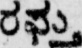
ರಫ್ತು
